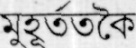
মুহূর্ততকৈ
